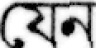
যেন
